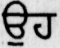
ਉਹ
